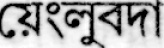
য়েংলুবদা
